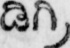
ಡಿಗ್ರಿ
